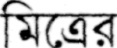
মিত্রের
